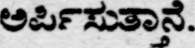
ಅರ್ಪಿಸುತ್ತಾನೆ.
